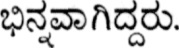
ಭಿನ್ನವಾಗಿದ್ದರು.
